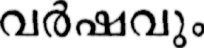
വര്‍ഷവും
